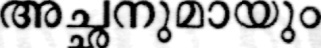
അച്ഛനുമായും
